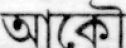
আকৌ
